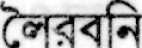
লৈরবনি
